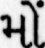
મોં
